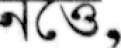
নত্তে,
